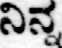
ನಿನ್ನ
